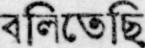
বলিতেছি
